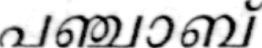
പഞ്ചാബ്
